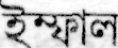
ইম্ফাল
